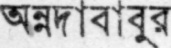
অন্নদাবাবুর
